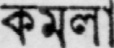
কমলা
